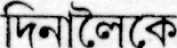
দিনালৈকে
